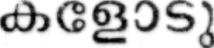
കളോടു
